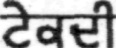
ਟੇਕਦੀ
